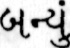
બન્યું
